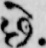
છે.
